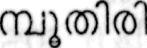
മ്പൂതിരി
